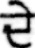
ਦੇ
